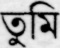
তুমি
